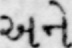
અને
